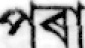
পৰা
